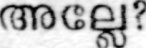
അല്ലേ?
